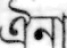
ঐনা
